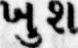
ખુશ
